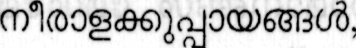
നീരാളക്കുപ്പായങ്ങള്‍,
